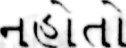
નહોતો
